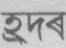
হ্ৰদৰ
